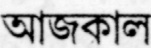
আজকাল
